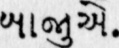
બાજુએ.
